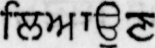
ਲਿਆਉਣ
